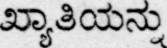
ಖ್ಯಾತಿಯನ್ನು
